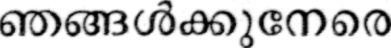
ഞങ്ങള്‍ക്കുനേരെ
